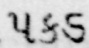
પકડ
